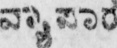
ವ್ಯಾಪಾರ
